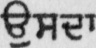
ਉਸਦਾ
